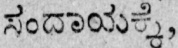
ಸಂದಾಯಕ್ಕೆ,
